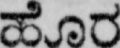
ಹೊರ
